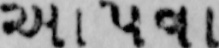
આપવા
